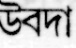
উবদা
